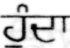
ਹੁੰਦਾ
